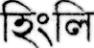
হিংলি
